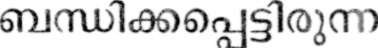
ബന്ധിക്കപ്പെട്ടിരുന്ന
